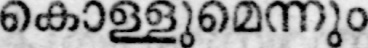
കൊള്ളുമെന്നും
